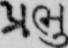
પ્રભુ
